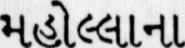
મહોલ્લાના
